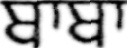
ਬਾਬਾ
